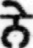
ਨੇ
